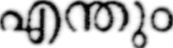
എന്തും
